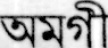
অমগী
